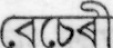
বেচেৰী
